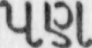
પણ
